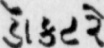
ડૉક્ટરે
